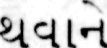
થવાને
